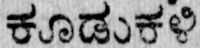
ಕೂಡುಕಳಿ
